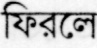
ফিরলে
